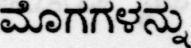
ಮೊಗಗಳನ್ನು
